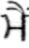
ਮੈਂ
